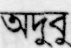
অদুবু
